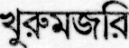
খুরুমজরি
